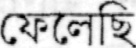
ফেলেছি
